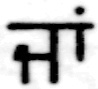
ਜਾਂ
